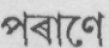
পৰাণে
